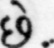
છે.
